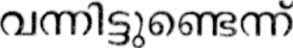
വന്നിട്ടുണ്ടെന്ന്
